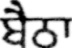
ਬੈਠਾ
